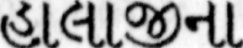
હાલાજીના
